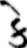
કે
